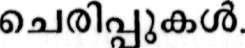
ചെരിപ്പുകള്‍.
